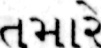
તમારે
